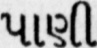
પાણી
